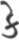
કે
